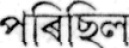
পৰিছিল
